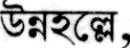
উন্নহল্লে,
